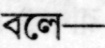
বলে–
